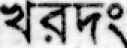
খরদং
